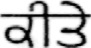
ਕੀਤੇ
